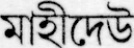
মাহীদেউ
